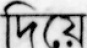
দিয়ে
